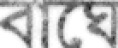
বাঘে
